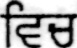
ਵਿਚ
